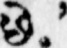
છે.'
